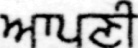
ਆਪਣੀ
